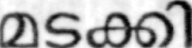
മടക്കി
